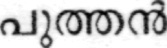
പുത്തന്‍
